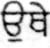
ਉਥੇ
